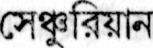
সেঞ্চুরিয়ান
